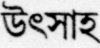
উত্সাহ
